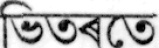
ভিতৰতে
